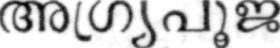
അഗ്ര്യപുജ
